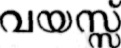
വയസ്സ്
